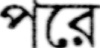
পরে
